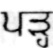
ਪੜ੍ਹ
